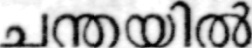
ചന്തയില്‍
